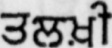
ਤਲਖ਼ੀ
